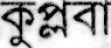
কুপ্লবা
